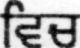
ਵਿਚ
